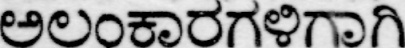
ಅಲಂಕಾರಗಳಿಗಾಗಿ
